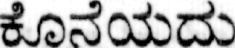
ಕೊನೆಯದು
